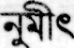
নুমীৎ
